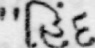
"હિંદ
